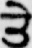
ਤੇ
